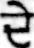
ਦੇ
